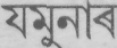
যমুনাৰ
